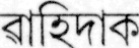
ৱাহিদাক
